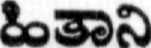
ಹಿತಾನಿ
